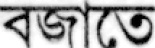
বজাতে
